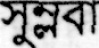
সুম্লবা
